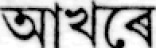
আখৰে
